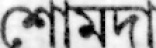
শোমদা
